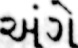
અંગે
